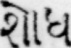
શોધ
